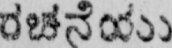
ರಚನೆಯು
